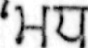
'ਮਧ
